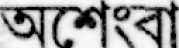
অশেংবা
